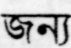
জন্য
